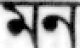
মন
